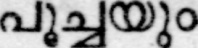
പൂച്ചയും
